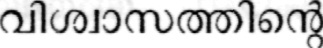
വിശ്വാസത്തിന്റെ
